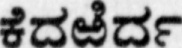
ಕೆದಱರ್ದ
